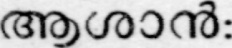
ആശാന്‍:
